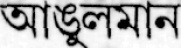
আঙুলমান
